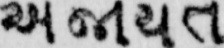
અજાયત
